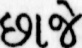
છાજે
